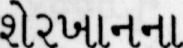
શેરખાનના
